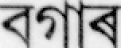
বগাৰ
